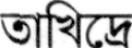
তাখিদ্রে
